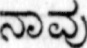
ನಾವು
